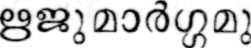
ഋജുമാര്‍ഗ്ഗമു
